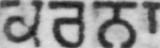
ਕਰਨਾ
